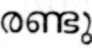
രണ്ടു
